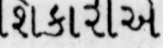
શિકારીએ
